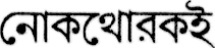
নোকথোরকই
